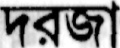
দরজা
